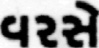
વરસે
